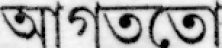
আগততো
